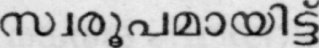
സ്വരൂപമായിട്ട്
